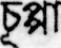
চূপ্পা
